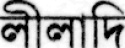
লীলাদি
